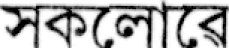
সকলোৱে
